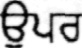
ਉਪਰ
